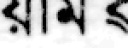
ময়াম
